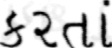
કરતાં
